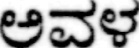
ಅವಳ
